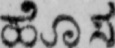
ಹೊಸ
